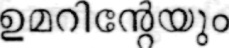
ഉമറിന്റേയും
